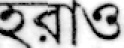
হারাও
